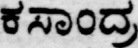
ಕಸಾಂದ್ರ
